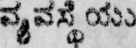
ವ್ಯವಸ್ಥೆಯು
